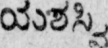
ಯಶಸ್ವಿ
